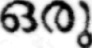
ഒരു
